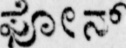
ಫೋನ್
